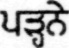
ਪੜ੍ਹਨੇ
